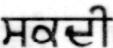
ਸਕਦੀ
